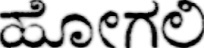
ಹೋಗಲಿ
